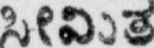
ಸೀಮಿತ
